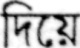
দিয়ে
